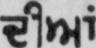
ਦੀਆਂ
